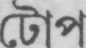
টোপ
